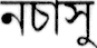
নচাসু
